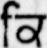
ਕਿ
